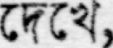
দেখে,
